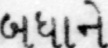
બધાને
